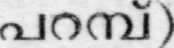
പറമ്പ്)
